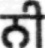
ਨੀ
